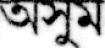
অসুম
